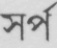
সৰ্প
